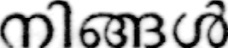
നിങ്ങള്‍
